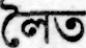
লৈত
